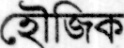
হৌজিক
